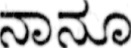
ನಾನೂ
